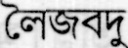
লৈজবদু
